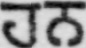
ਹਨ
